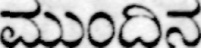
ಮುಂದಿನ
